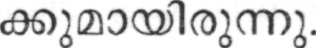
ക്കുമായിരുന്നു.
